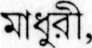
মাধুরী,
